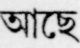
আছে
